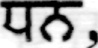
ਧਨ,
